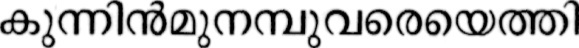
കുന്നിന്‍മുനമ്പുവരെയെത്തി
